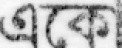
একো
